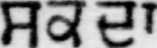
ਸਕਦਾ
